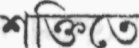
শক্তিতে
